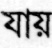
যায়
